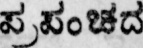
ಪ್ರಪಂಚದ
